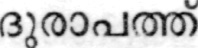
ദുരാപത്ത്
